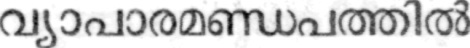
വ്യാപാരമണ്ഡപത്തില്‍
